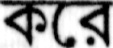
করে
